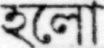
হলো
